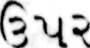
ઉપર
